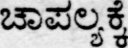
ಚಾಪಲ್ಯಕ್ಕೆ
